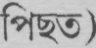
পিছত)
